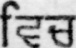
ਵਿਚ
